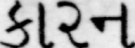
કારન
